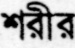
শরীর
